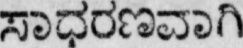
ಸಾಧರಣವಾಗಿ
